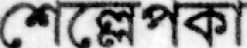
শেল্লেপকা
